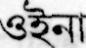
ওইনা
